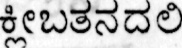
ಕ್ಲೀಬತನದಲಿ
